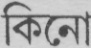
কিনো
